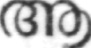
ആ
